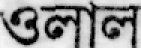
ওলাল
